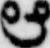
ಆ
